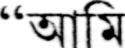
“আমি
